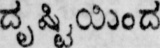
ದೃಷ್ಟಿಯಿಂದ
